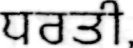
ਧਰਤੀ,
